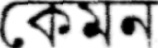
কেমন
